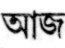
আজ
